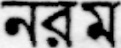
নরম
